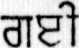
ਗਈ
